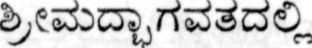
ಶ್ರೀಮದ್ಭಾಗವತದಲ್ಲಿ
